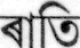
ৰাতি
